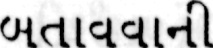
બતાવવાની
